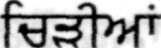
ਚਿੜੀਆਂ
